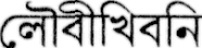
লৌবীখিবনি
